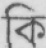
কি
